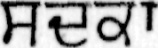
ਸਦਕਾ
